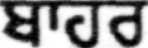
ਬਾਹਰ
